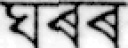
ঘৰৰ
